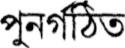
পুনর্গঠিত
